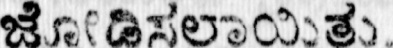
ಜೋಡಿಸಲಾಯಿತು.
